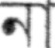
না
